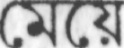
মেয়ে
